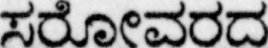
ಸರೋವರದ
